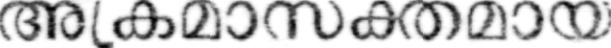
അക്രമാസക്തമായ
